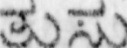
ತುಸು
